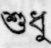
শুধু
